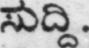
ಸುದ್ದಿ.
